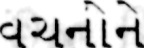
વચનોને
